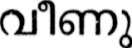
വീണു
